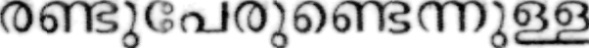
രണ്ടുപേരുണ്ടെന്നുള്ള
